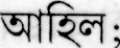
আহিল;
